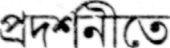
প্রদর্শনীতে
